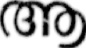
ആ
